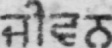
ਜੀਵਨ
